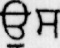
ਉਸ
